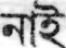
নাই
